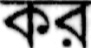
কর
